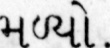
મળ્યો.
